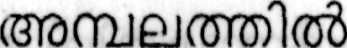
അമ്പലത്തില്‍
